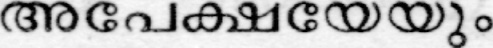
അപേക്ഷയേയും
